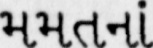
મમતનાં
